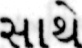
સાથે
